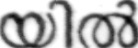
യില്‍
